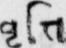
વૃત્તિ
